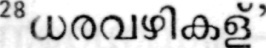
28ധരവഴികള്'
